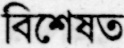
বিশেষত
